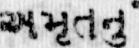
અમૃતનું
